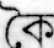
কৈ
